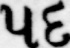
પદ
